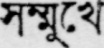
সম্মুখে
